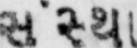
સંસ્થા
